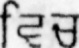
ਵਿਚ
